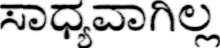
ಸಾಧ್ಯವಾಗಿಲ್ಲ
